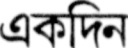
একদিন
